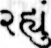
રહ્યું
